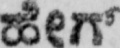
ಹೇಗ್
